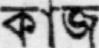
কাজ
